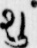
શું
